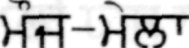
ਮੌਜ-ਮੇਲਾ
